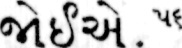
જોઈએ.૫૬
